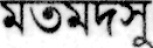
মতমদসু
